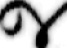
જ
